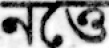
নত্তে
